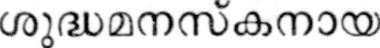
ശുദ്ധമനസ്കനായ
